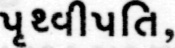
પૃથ્વીપતિ,
